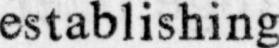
establishing
